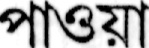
পাওয়া
